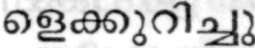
ളെക്കുറിച്ചു
